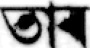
তাৰ
